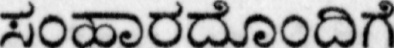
ಸಂಹಾರದೊಂದಿಗೆ
